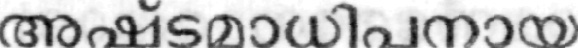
അഷ്ടമാധിപനായ
